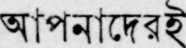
আপনাদেরই
